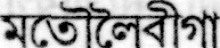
মতৌলৈবীগা
